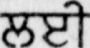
ਲਈ
